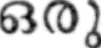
ഒരു
